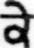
ਕੇ
